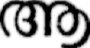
ആ
